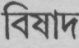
বিষাদ
